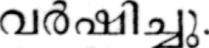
വര്‍ഷിച്ചു.
